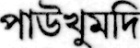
পাউখুমদি
